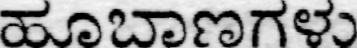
ಹೂಬಾಣಗಳು
